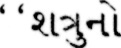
"શત્રુનો
